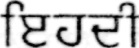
ਇਹਦੀ
